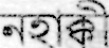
নহাক্কী
